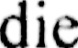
die
